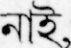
নাই,
